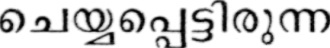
ചെയ്യപ്പെട്ടിരുന്ന
